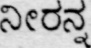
ನೀರನ್ನ
